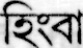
হিংবা
